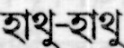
হাথু-হাথু
